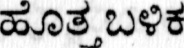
ಹೊತ್ತಬಳಿಕ
